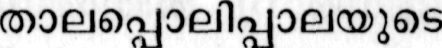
താലപ്പൊലിപ്പാലയുടെ
